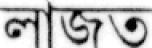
লাজত
